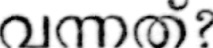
വന്നത്?
